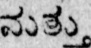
ಮತ್ತು
